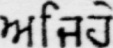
ਅਜਿਹੇ
